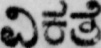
ವಿಕತೆ
